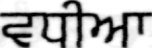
ਵਧੀਆ
